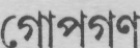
গোপগণ
